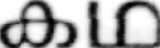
കഥ
